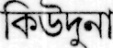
কিউদুনা
